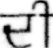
ਦੀ
